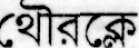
থৌরক্লে
